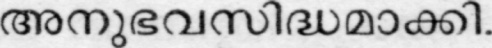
അനുഭവസിദ്ധമാക്കി.
